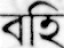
বহি
